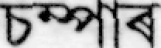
চম্পাৰ
